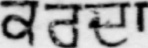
ਕਰਦਾ
